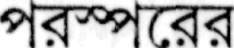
পরস্পরের
